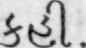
કહી.
